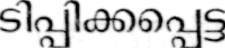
ടിപ്പിക്കപ്പെട്ട
